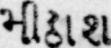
મીઠાશ
